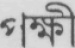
পক্ষী
